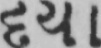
દયા
